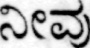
ನೀವು
